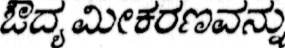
ಔದ್ಯಮೀಕರಣವನ್ನು
